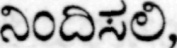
ನಿಂದಿಸಲಿ,
